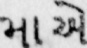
માએ
